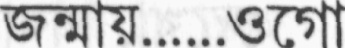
জন্মায়....ওগো
